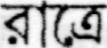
রাত্রে
